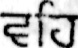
ਵਹਿ
